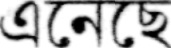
এনেছে
